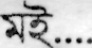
মই....
